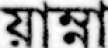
য়াম্না
